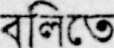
বলিতে
